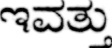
ಇವತ್ತು
